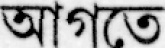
আগতে
